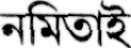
নমিতাই
